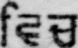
ਵਿਚ
